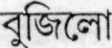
বুজিলো
